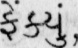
ફેંક્યું,
